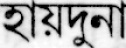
হায়দুনা
